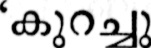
‘കുറച്ചു
